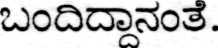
ಬಂದಿದ್ದಾನಂತೆ.
